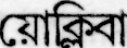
য়োক্লিবা
